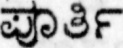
ಪೂರ್ತಿ
